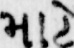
માટે
